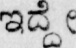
ಇದ್ದೇ
